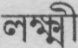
লক্ষ্মী
